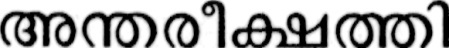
അന്തരീക്ഷത്തി
